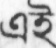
এই
